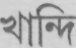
খান্দি
